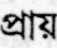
প্রায়
